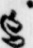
હું
